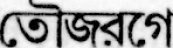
তৌজরগে
